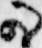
જે
